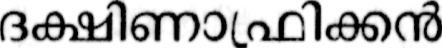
ദക്ഷിണാഫ്രിക്കന്‍
